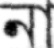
না
